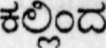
ಕಲ್ಲಿಂದ
